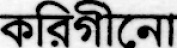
করিগীনো
